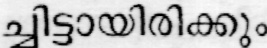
ച്ചിട്ടായിരിക്കും
